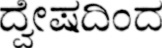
ದ್ವೇಷದಿಂದ
